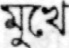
মুখে
